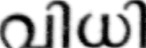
വിധി
